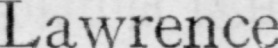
Lawrence
